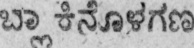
ಬ್ಲಾಕಿನೊಳಗಣ
